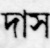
দাস
